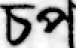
চপ
